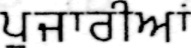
ਪੁਜਾਰੀਆਂ
